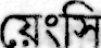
য়েংসি
